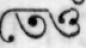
তেওঁ
